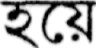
হয়ে
